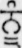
ਨੂੰ
